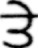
ਤੇ
